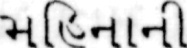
મહિનાની
